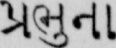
પ્રભુના
